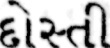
દોસ્તી
